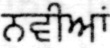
ਨਵੀਆਂ
